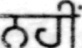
ਨਹੀਂ
